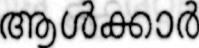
ആള്‍ക്കാര്‍
